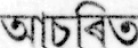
আচৰিত
